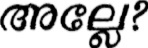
അല്ലേ?
